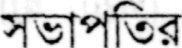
সভাপতির
